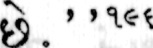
છે."૧૯૬
